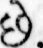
છે.
